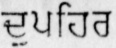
ਦੁਪਹਿਰ
